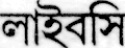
লাইবসি
